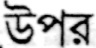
উপর
